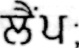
ਲੈਂਪ;
